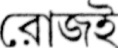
রোজই
